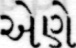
એણે
